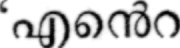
'എൻെറ
